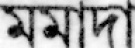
মমাদা
